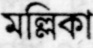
মল্লিকা
